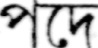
পদে
